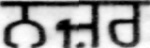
ਨਜ਼ਰ
